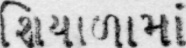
શિયાળામાં
